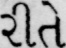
રીતે
